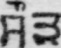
ਸੌੜ
